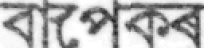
বাপেকৰ
